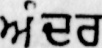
ਅੰਦਰ
